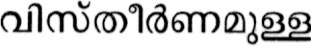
വിസ്തീര്‍ണമുള്ള
